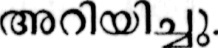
അറിയിച്ചു.
